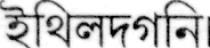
ইথিলদগনি।
